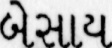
બેસાય
